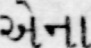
એના
